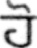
ਹੋ
